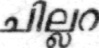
ചില്ലറ
